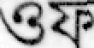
ওফ
